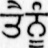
ਤੈਨੂੰ
